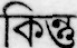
কিন্তু
